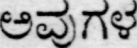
ಅವುಗಳ
